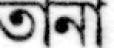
তানা
